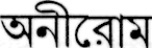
অনীরোম
